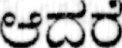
ಆದರೆ
